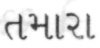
તમારા
